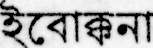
ইবোক্কনা
